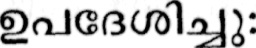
ഉപദേശിച്ചു:
